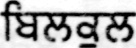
ਬਿਲਕੁਲ
